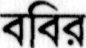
ববির
